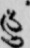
હું
